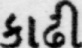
કાઢી
